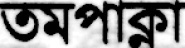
তমপাক্না
